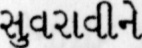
સુવરાવીને
